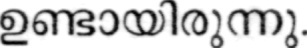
ഉണ്ടായിരുന്നു.
